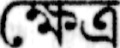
ক্ষেত্র
